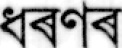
ধৰণৰ
